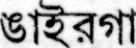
ঙাইরগা
